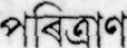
পৰিত্রাণ
